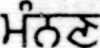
ਮੰਨਣ
